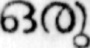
ഒരു
